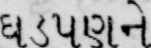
ઘડપણને
